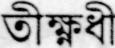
তীক্ষ্ণধী
